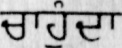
ਚਾਹੁੰਦਾ
